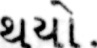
થયો.
